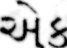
એક
